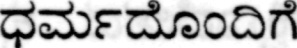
ಧರ್ಮದೊಂದಿಗೆ
